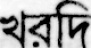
খরদি
